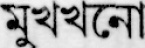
মুখখনো
